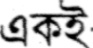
একই
